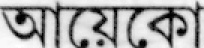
আয়েকো
